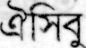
ঐসিবু
